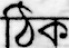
ঠিক
